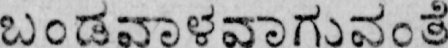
ಬಂಡವಾಳವಾಗುವಂತೆ
